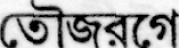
তৌজরগে
